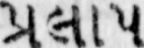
પ્રલાપ
